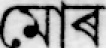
মোৰ
